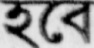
হবে
